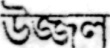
উজ্জল
